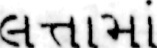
લત્તામાં
